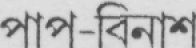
পাপ-বিনাশ
